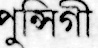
পুন্সিগী
